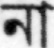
না
